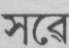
সৱে
